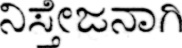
ನಿಸ್ತೇಜನಾಗಿ
